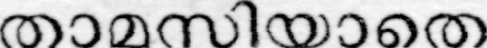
താമസിയാതെ
